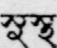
সুস্থ
